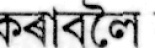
কৰাবলৈ
